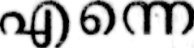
എന്നെ
